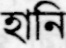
হানি
